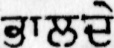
ਭਾਲਦੇ
